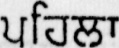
ਪਹਿਲਾ
